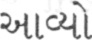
આવ્યો
